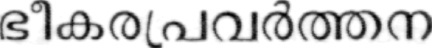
ഭീകരപ്രവര്‍ത്തന
